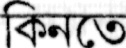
কিনতে
